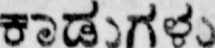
ಕಾಡುಗಳು
